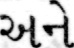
અને
